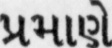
પ્રમાણે
